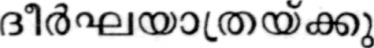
ദീര്‍ഘയാത്രയ്ക്കു
